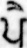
ਪੈ
